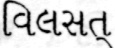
વિલસત્
